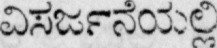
ವಿಸರ್ಜನೆಯಲ್ಲಿ
